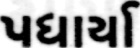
પધાર્યા
